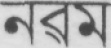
নৱম
